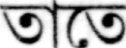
তাতে
